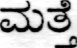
ಮತ್ತೆ
